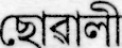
ছোৱালী
